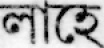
লাহে
